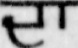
ਦਾ
